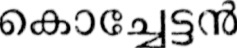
കൊച്ചേട്ടന്‍
